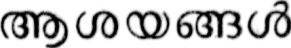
ആശയങ്ങള്‍
